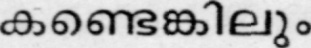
കണ്ടെങ്കിലും
